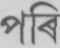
পৰি
